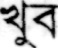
খুব
